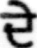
ਦੇ
